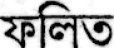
ফলিত
